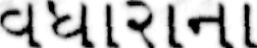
વધારાના
